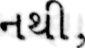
નથી,
